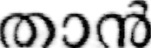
താന്‍
